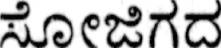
ಸೋಜಿಗದ
